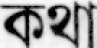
কথা
